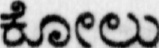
ಕೋಲು
